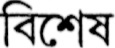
বিশেষ
